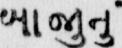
બાજુનું
